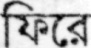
ফিরে
